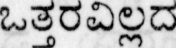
ಒತ್ತರವಿಲ್ಲದ
